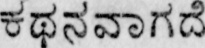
ಕಥನವಾಗದೆ
